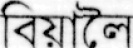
বিয়ালৈ
